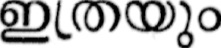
ഇത്രയും
